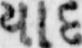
યાદ
